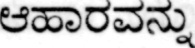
ಆಹಾರವನ್ನು
